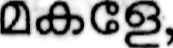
മകളേ,
